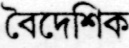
বৈদেশিক
